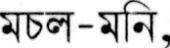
মচল-মনি,
